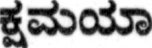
ಕ್ಷಮಯಾ
